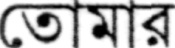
তোমার
